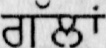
ਗੱਲਾਂ
